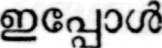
ഇപ്പോള്‍
